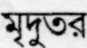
মৃদুতর
